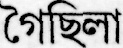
গৈছিলা
